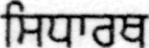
ਸਿਧਾਰਥ
